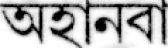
অহানবা
